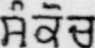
ਸੰਕੋਚ
